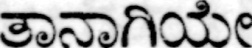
ತಾನಾಗಿಯೇ
